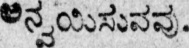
ಅನ್ವಯಿಸುವವು.
